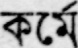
কর্মে
